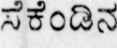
ಸೆಕೆಂಡಿನ
